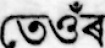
তেওঁৰ
